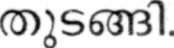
തുടങ്ങി.
